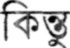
কিন্তু
